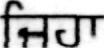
ਜਿਹਾ
